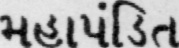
મહાપંડિત
